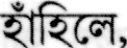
হাঁহিলে,
